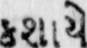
કશાયે
